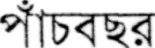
পাঁচবছর
